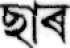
ছাৰ
